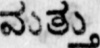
ಮತ್ತು
